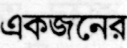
একজনের
